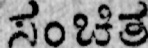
ಸಂಚಿತ
